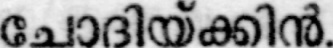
ചോദിയ്ക്കിന്‍.
